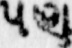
પણ
